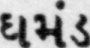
ઘમંડ
